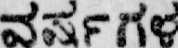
ವರ್ಷಗಳ
